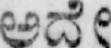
ಅದೇ
